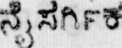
ನೈಸರ್ಗಿಕ
